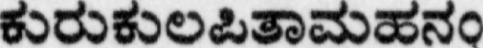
ಕುರುಕುಲಪಿತಾಮಹನಂ
